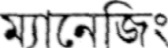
ম্যানেজিং
